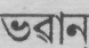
ভৱান
